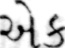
એક
